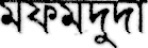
মফমদুদা
